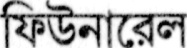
ফিউনারেল
